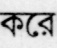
করে
